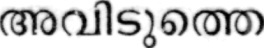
അവിടുത്തെ
